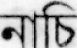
নাচি
